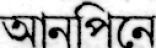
আনপিনে
